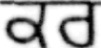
ਕਰ
